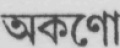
অকণো
